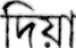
দিয়া
